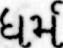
ધર્મ
